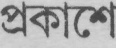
প্ৰকাশে
